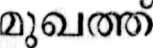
മുഖത്ത്
